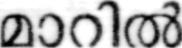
മാറില്‍
